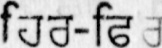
ਹਿਰ-ਫਿਰ
